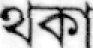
থকা
